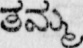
ತಮ್ಮ
